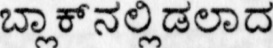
ಬ್ಲಾಕ್‌ನಲ್ಲಿಡಲಾದ
